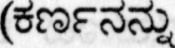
(ಕರ್ಣನನ್ನು
